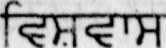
ਵਿਸ਼ਵਾਸ
